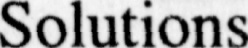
Solutions
